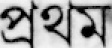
প্রথম
